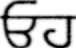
ਓਹ
